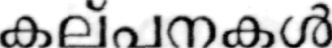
കല്പനകള്‍
